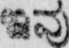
ಇವು
